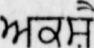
ਅਕਸ਼ੈ
